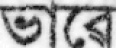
ভাৱে
